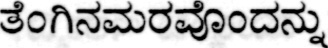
ತೆಂಗಿನಮರವೊಂದನ್ನು
